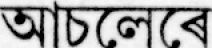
আচলেৰে
